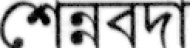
শেন্নবদা
